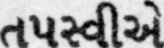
તપસ્વીએ
